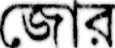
জোর
